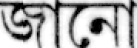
জানো
